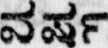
ವರ್ಷ
